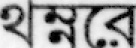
থম্নরে
